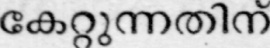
കേറ്റുന്നതിന്
